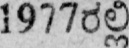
1977ರಲ್ಲಿ
